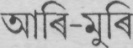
আৰি-মুৰি
